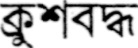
ক্রুশবদ্ধ
